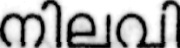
നിലവി
